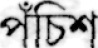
পঁচিশ
